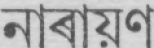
নাৰায়ণ
